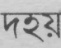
দহয়
